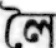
লৈ
